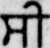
ਸੀ
